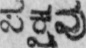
ಪಕ್ಷವು
